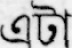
এটা
